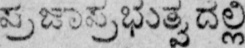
ಪ್ರಜಾಪ್ರಭುತ್ವದಲ್ಲಿ
